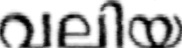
വലിയ
